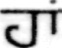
ਹਾਂ
